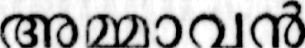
അമ്മാവന്‍
